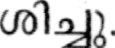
ശിച്ചു.
